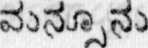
ಮನ್ಸೂನು
